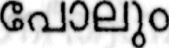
പോലും
